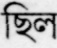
ছিল
